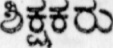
ಶಿಕ್ಷಕರು
